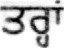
ਤਰ੍ਹਾਂ
